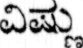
ವಿಷ್ಣು
